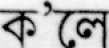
ক'লে
